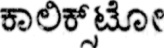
ಕಾಲಿಕ್ಸ್ದೋ
